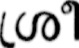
ശ്രീ
